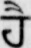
ਹੈ
